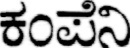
ಕಂಪೆನಿ
